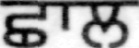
ਛਾਲ
